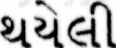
થયેલી
